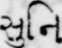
સુનિ
